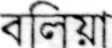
বলিয়া
